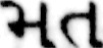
મત
